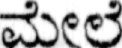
ಮೇಲೆ
